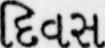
દિવસ
